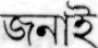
জনাই
